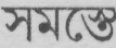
সমস্তে
